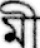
মী
